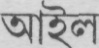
আইল
